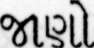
જાણો
